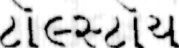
ટૉલ્સટૉય
